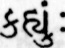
કહ્યું:
